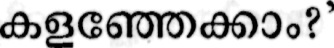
കളഞ്ഞേക്കാം?’
